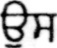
ਉਸ
